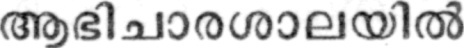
ആഭിചാരശാലയില്‍
